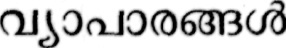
വ്യാപാരങ്ങള്‍
